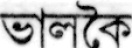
ভালকৈ
